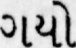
ગયો
